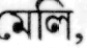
মেলি,
